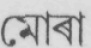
মোৰা
